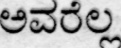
ಅವರೆಲ್ಲ
